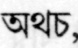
অথচ,
